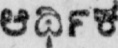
ಆರ್ಥಿಕ
